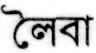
লৈবা
